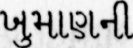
ખુમાણની
